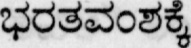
ಭರತವಂಶಕ್ಕೆ
